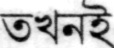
তখনই
